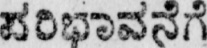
ಪರಿಭಾವನೆಗೆ
